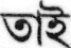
তাই
